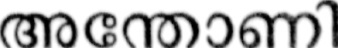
അന്തോണി
